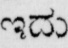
ಇದು
